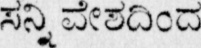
ಸನ್ನಿವೇಶದಿಂದ
